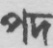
পদ
